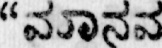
“ಮಾನವ
